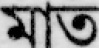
মাত
